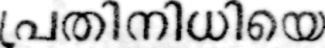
പ്രതിനിധിയെ
